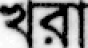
খরা
